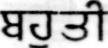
ਬਹੁਤੀ
